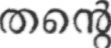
തന്റെ
